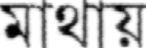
মাথায়
